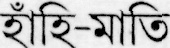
হাঁহি-মাতি
